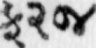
ફરજ
